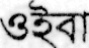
ওইবা
